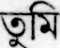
তুমি
